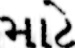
માટે
